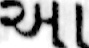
આ
